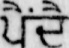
ਪੈਂਦੈ
